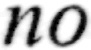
no
